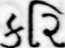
કરિ
